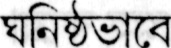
ঘনিষ্ঠভাবে
